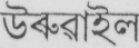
উৰুৱাইল
